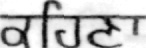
ਕਹਿਣਾ
